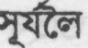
সূৰ্যলৈ
